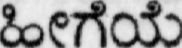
ಹೀಗೆಯೆ
